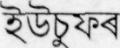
ইউচুফৰ
